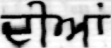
ਦੀਆਂ
